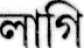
লাগি
